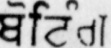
ਬੋਟਿੰਗ
